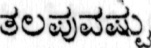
ತಲಪುವಷ್ಟು
